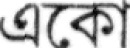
একো
